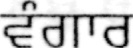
ਵੰਗਾਰ
